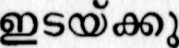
ഇടയ്ക്കു
